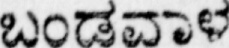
ಬಂಡವಾಳ
